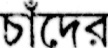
চাঁদের
